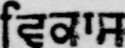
ਵਿਕਾਸ
